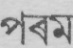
পৰম
